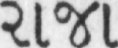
રાજા
